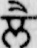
ਲੈ
